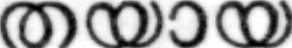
തയായ
